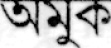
অমুক
